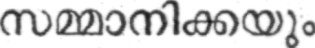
സമ്മാനിക്കയും
